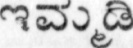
ಇಮ್ಮಡಿ
